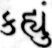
કહ્યું
